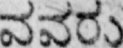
ವವರು
